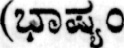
(ಭಾಷ್ಯಂ
